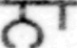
ਨਾ
